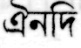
ঐনদি
